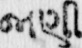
જાણી
